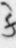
કે
